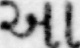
આ
